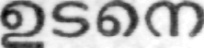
ഉടനെ
